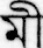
মী
